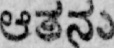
ಆತನು
